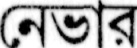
নেভার
